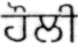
ਹੌਲੀ
